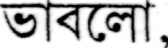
ভাবলো,
